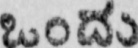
ಒಂದು
